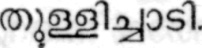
തുള്ളിച്ചാടി.
